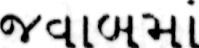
જવાબમાં
